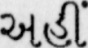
અહીં
